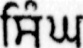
ਸਿੰਘ
